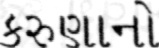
કરુણાનો
